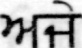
ਅਜੇ
